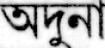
অদুনা
